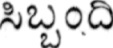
ಸಿಬ್ಬಂದಿ
